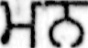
ਮਨ
